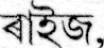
ৰাইজ,
